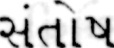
સંતોષ
